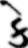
કે
